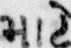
માટે
